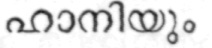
ഹാനിയും
